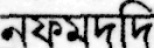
নফমদদি
